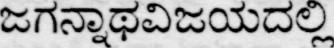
ಜಗನ್ನಾಥವಿಜಯದಲ್ಲಿ
